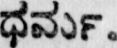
ಧರ್ಮ.
